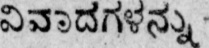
ವಿವಾದಗಳನ್ನು
